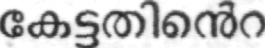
കേട്ടതിന്റെ
